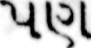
પણ
